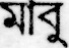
মাবু
